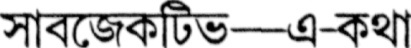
সাবজেকটিভ–এ-কথা
